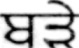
ਬੜੇ
